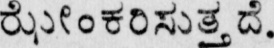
ಝೇಂಕರಿಸುತ್ತದೆ.
